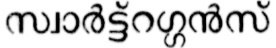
സ്വാര്‍ട്ട്റഗ്ഗന്‍സ്
